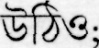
উঠিও;
